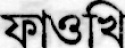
ফাওখি
